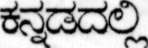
ಕನ್ನಡದಲ್ಲಿ
